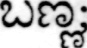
ಬಣ್ಣ;
